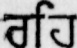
ਰਹਿ
